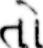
તો
